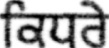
ਕਿਧਰੇ
